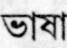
ভাষা
